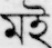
মই
